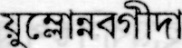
য়ুম্লোন্নবগীদা
